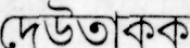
দেউতাকক
